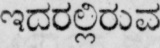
ಇದರಲ್ಲಿರುವ
